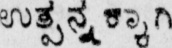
ಉತ್ಪನ್ನಕ್ಕಾಗಿ
